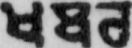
ਖਬਰ
